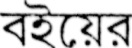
বইয়ের
